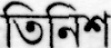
তিনিশ
